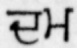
ਦਮ
